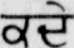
ਕਦੇ
